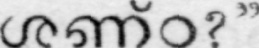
ശണ്ഠ?”
